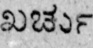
ಖರ್ಚು
